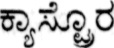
ಕ್ಯಾಸ್ಟ್ರೊರ
